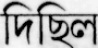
দিছিল
